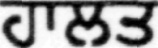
ਹਾਲਤ
